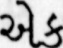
એક
